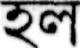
হল
